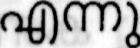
എന്നു
